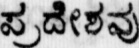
ಪ್ರದೇಶವು
